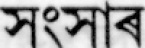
সংসাৰ
